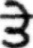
ਤੇ
